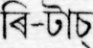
ৰি-টাচ্‌
